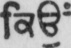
ਕਿਉਂ
